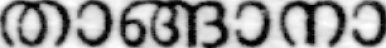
താങ്ങാനാ
